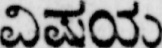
ವಿಷಯ
